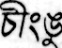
চীংঙু
